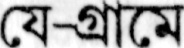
যে-গ্রামে
